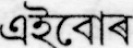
এইবোৰ
